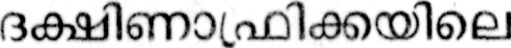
ദക്ഷിണാഫ്രിക്കയിലെ
